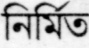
নির্মিত
